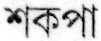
শকপা
